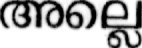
അല്ലെ
